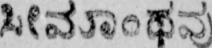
ಸೀಮಾಂಥವು
